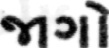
જાગો
